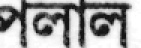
পলাল
